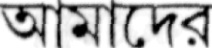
আমাদের
